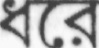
ধরে
